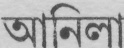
আনিলা
